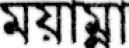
ময়াম্না
